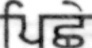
ਪਿਛੇ
